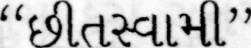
છીતસ્વામી
